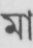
মা
